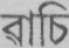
ৱাচি
